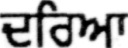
ਦਰਿਆ
